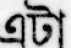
এটা
